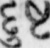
દુષ્ટ
